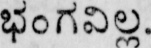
ಭಂಗವಿಲ್ಲ.
